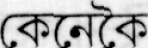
কেনেকৈ
